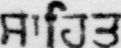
ਸਾਹਿਤ
